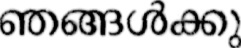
ഞങ്ങള്‍ക്കു
